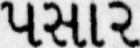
પસાર
